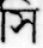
সি
